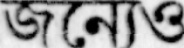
জন্যেও
